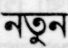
নতুন
